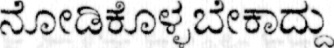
ನೋಡಿಕೊಳ್ಳಬೇಕಾದ್ದು
